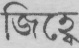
জিহ্বে
